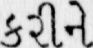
કરીને
